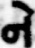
ને
